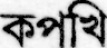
কপখি
